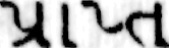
પ્રાપ્ત
